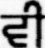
ਵੀ
